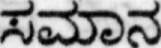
ಸಮಾನ
